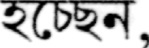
হচ্ছেন,
